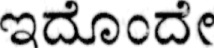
ಇದೊಂದೇ
